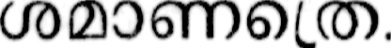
ശമാണത്രെ.
